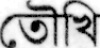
তৌখি
